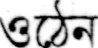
ওঠেন
